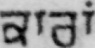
ਕਾਰਾਂ
